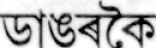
ডাঙৰকৈ
